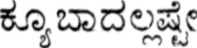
ಕ್ಯೂಬಾದಲ್ಲಷ್ಟೇ
